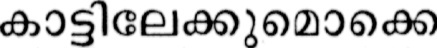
കാട്ടിലേക്കുമൊക്കെ
